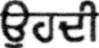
ਉਹਦੀ
